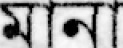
মানা
